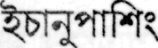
ইচানুপাশিং
